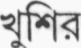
খুশির
